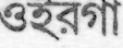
ওইরগা
